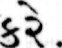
કરે.
